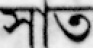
সাত
